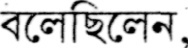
বলেছিলেন,
